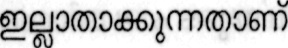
ഇല്ലാതാക്കുന്നതാണ്
